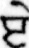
ਏ
